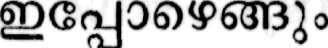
ഇപ്പോഴെങ്ങും
